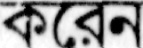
করেন
